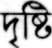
দৃষ্টি
